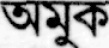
অমুক
